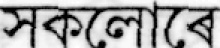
সকলোৰে
